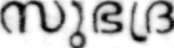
സുഭദ്ര
